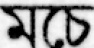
মচে
